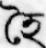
হৈ
